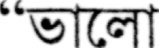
“ভালো
